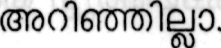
അറിഞ്ഞില്ലാ.
